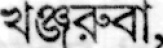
খঞ্জরুবা,
